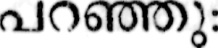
പറഞ്ഞു:
